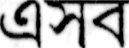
এসব
